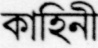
কাহিনী
